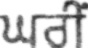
ਘਰੀਂ
